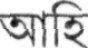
আহি
